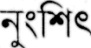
নুংশিৎ
